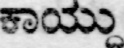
ಕಾಯ್ದು
